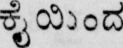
ಕೈಯಿಂದ
